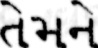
તેમને
